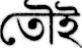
তৌই
